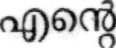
എന്റെ
